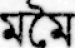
মমৈ
